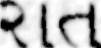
રાત
